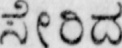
ಸೇರಿದ
